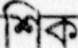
শিক
